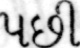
પછી
